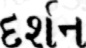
દર્શન
